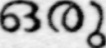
ഒരു
